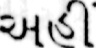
અહીં
